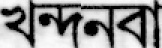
খন্দনবা
